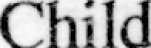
Child
